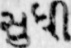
સુધી
